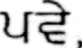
ਪਵੇ,
